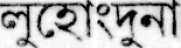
লুহোংদুনা
